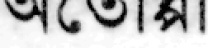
অতোপ্পা
